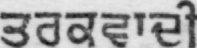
ਤਰਕਵਾਦੀ
